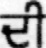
ਦੀ
